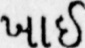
ખાઈ
